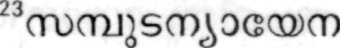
23സമ്പുടന്യായേന
